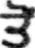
ਤੋਂ
